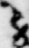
કે
